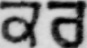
ਕਰ
